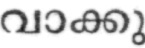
വാക്കു
